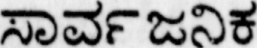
ಸಾರ್ವಜನಿಕ
